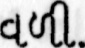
વળી.
